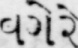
વગેરે
